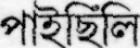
পাইছিলি
